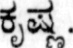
ಕೃಷ್ಣ.
